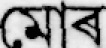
মোৰ
